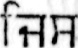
ਜਿਸ
